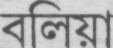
বলিয়া
